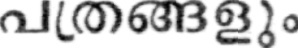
പത്രങ്ങളും
